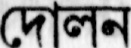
দোলন
